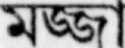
মজ্জা
